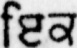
ਇਕ
